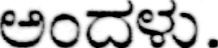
ಅಂದಳು.
